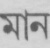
মান
